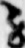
કે
